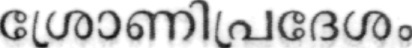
ശ്രോണിപ്രദേശം
